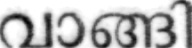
വാങ്ങി
